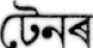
টেনৰ
